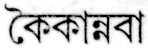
কৈকান্নবা
